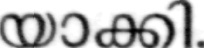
യാക്കി.
